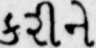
કરીને
